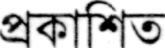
প্রকাশিত
